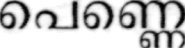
പെണ്ണെ
